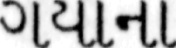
ગયાના
